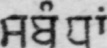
ਸਬੰਧਾਂ
